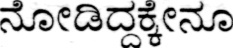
ನೋಡಿದ್ದಕ್ಕೇನೂ
